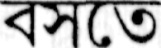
বসতে
